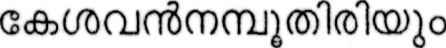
കേശവന്‍നമ്പൂതിരിയും
